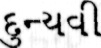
દુન્યવી
